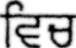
ਵਿਚ
